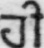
ਹੀ
